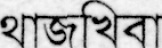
থাজখিবা
